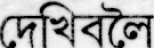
দেখিবলৈ
